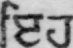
ਇਹ
